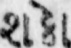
શકો
